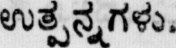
ಉತ್ಪನ್ನಗಳು.
